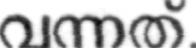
വന്നത്.
